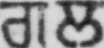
ਗਲ
